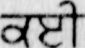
ਕਈ
